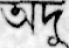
অদু
